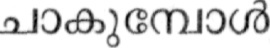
ചാകുമ്പോള്‍
